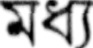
মধ্য
